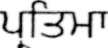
ਪ੍ਰਤਿਮਾ
